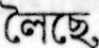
লৈছে,
